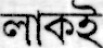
লাকই
